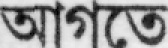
আগতে
